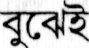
বুঝেই
